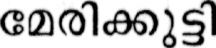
മേരിക്കുട്ടി
